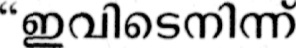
“ഇവിടെനിന്ന്
